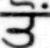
ਤੋਂ
